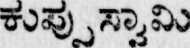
ಕುಪ್ಪುಸ್ವಾಮಿ
